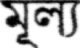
মূল্য
